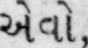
એવો,
